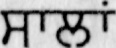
ਸਾਲਾਂ
